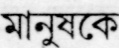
মানুষকে
